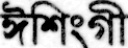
ঈশিংগী
